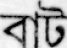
বাট
